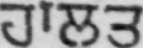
ਹਾਲਤ
